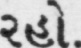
રહો.
